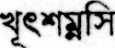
খূৎশম্নসি
